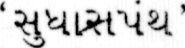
'સુધાસપથ'
